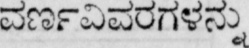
ವರ್ಣವಿವರಗಳನ್ನು
